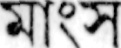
মাংস
